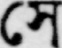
সে
